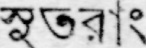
সুতরাং
